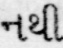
નથી
